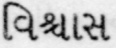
વિશ્ચાસ
